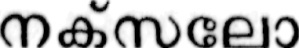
നക്സലോ
